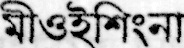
মীওইশিংনা
